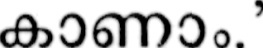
കാണാം.’
